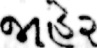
જાહેર
